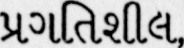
પ્રગતિશીલ,
